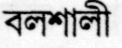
বলশালী
